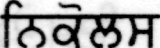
ਨਿਕੋਲਸ
